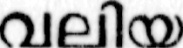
വലിയ
